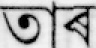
তাৰ
